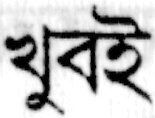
খুবই
